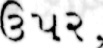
ઉપર,
